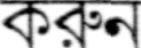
করুন
